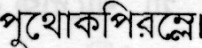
পুথোকপিরম্লে।
